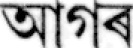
আগৰ
